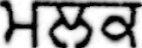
ਮਲਕ
